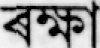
ৰক্ষা
